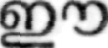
ഈ
